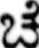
ಚೆ
